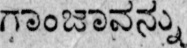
ಗಾಂಜಾವನ್ನು
